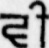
ਵੀ
